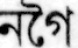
নগৈ
